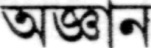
অজ্ঞান
